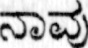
ನಾವು
